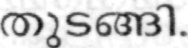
തുടങ്ങി.
